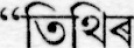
"তিথিৰ
